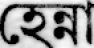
হেন্না
